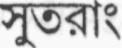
সুতরাং
